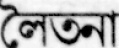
লৈতনা
